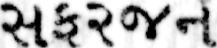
સફરજન
